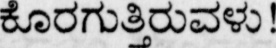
ಕೊರಗುತ್ತಿರುವಳು!
